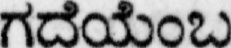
ಗದೆಯೆಂಬ
